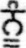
ਨੂੰ
